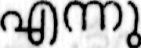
എന്നു
